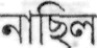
নাছিল
